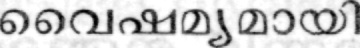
വൈഷമ്യമായി
